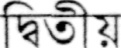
দ্বিতীয়
